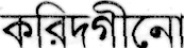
করিদগীনো
